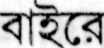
বাইরে
